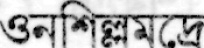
ওনশিল্লমদ্রে
